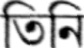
তিনি
